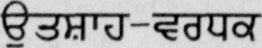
ਉਤਸ਼ਾਹ-ਵਰਧਕ
